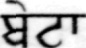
ਬੇਟਾ
